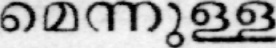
മെന്നുള്ള
